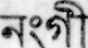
নংগী
